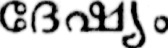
ദേഷ്യം
